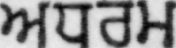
ਅਧਰਮ
